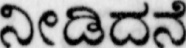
ನೀಡಿದನೆ
